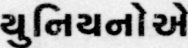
યુનિયનોએ
